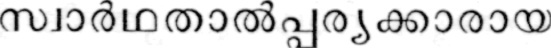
സ്വാര്‍ഥതാല്‍പ്പര്യക്കാരായ
